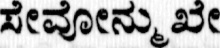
ಸೇವೋನ್ಮುಖೇ
